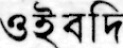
ওইবদি
